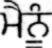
ਮੈਨੂੰ
